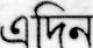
এদিন
